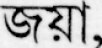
জয়া,
